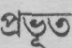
প্ৰভূত
